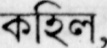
কহিল,
